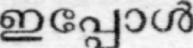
ഇപ്പോള്‍
